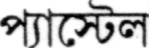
প্যাস্টেল
